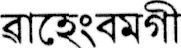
ৱাহেংবমগী
